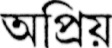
অপ্রিয়
